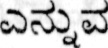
ಎನ್ನುವ
